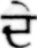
ਦੇ
